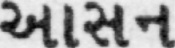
આસન
